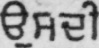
ਉਸਦੀ
